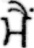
ਮੈਂ
